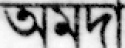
অমদা
